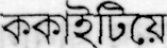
ককাইটিয়ে
